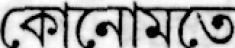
কোনোমতে
